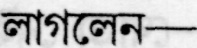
লাগলেন–
